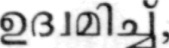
ഉദ്വമിച്ച്,
